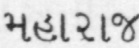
મહારાજ
